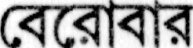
বেরোবার
